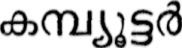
കമ്പ്യൂട്ടര്‍
